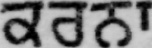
ਕਰਨਾ
